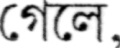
গেলে,
